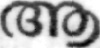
ആ
